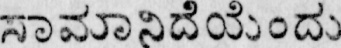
ಸಾಮಾನಿದೆಯೆಂದು
